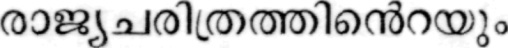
രാജ്യചരിത്രത്തിന്റെയും
